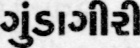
ગુંડાગીરી
